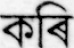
কৰি
